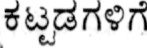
ಕಟ್ಟಡಗಳಿಗೆ
